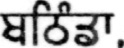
ਬਠਿੰਡਾ,
